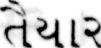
તૈયાર
